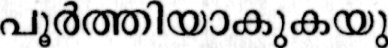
പൂര്‍ത്തിയാകുകയു
